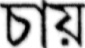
চায়
